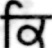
ਕਿ
